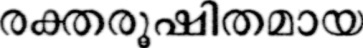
രക്തരൂഷിതമായ
